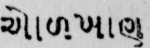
ઓળખાણ
